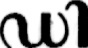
ഡി
